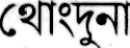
থোংদুনা
